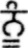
ਨੂੰ
